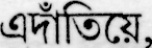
এদাঁতিয়ে,
